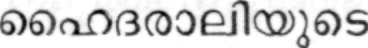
ഹൈദരാലിയുടെ
